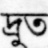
দ্রুত
